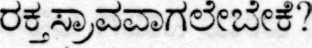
ರಕ್ತಸ್ರಾವವಾಗಲೇಬೇಕೆ?
